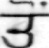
ਤੋਂ
